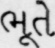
ભૂતે
